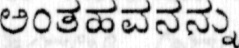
ಅಂತಹವನನ್ನು
